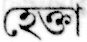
হেক্তা
